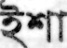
ইশা
